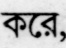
করে,
